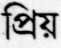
প্রিয়
